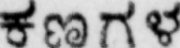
ಕಣಗಳ
